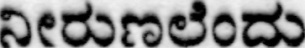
ನೀರುಣಲೆಂದು
